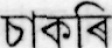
চাকৰি
